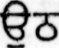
ਉਠ
